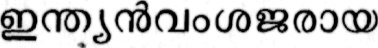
ഇന്ത്യന്‍വംശജരായ
